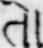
તો
